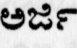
ಅರ್ಜಿ
